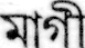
মাগী
